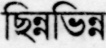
ছিন্নভিন্ন
